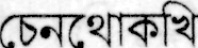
চেনথোকখি
